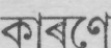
কাৰণে
